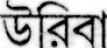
উরিবা
